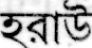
হরাউ
